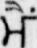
ਮੈਂ
